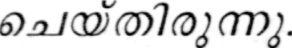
ചെയ്തിരുന്നു.
